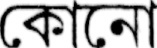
কোনো
